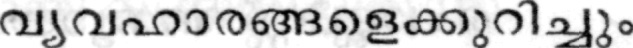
വ്യവഹാരങ്ങളെക്കുറിച്ചും
